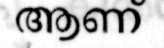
ആണ്
